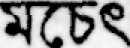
মচেৎ
